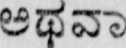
ಅಥವಾ
